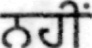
ਨਹੀਂ
